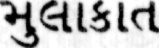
મુલાકાત
